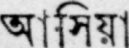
আসিয়া
